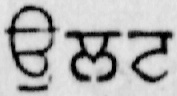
ਉਲਟ
